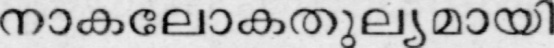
നാകലോകതുല്യമായി
